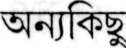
অন্যকিছু
